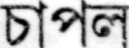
চাপল
